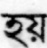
হয়
